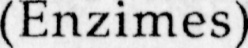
(Enzimes)
